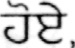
ਹੋਏ,
